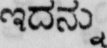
ಇದನ್ನು
